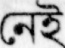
নেই
